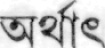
অর্থাৎ
